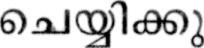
ചെയ്യിക്കു
